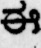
ಈ
